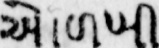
ઓળખી
